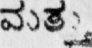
ಮತ್ತು
